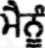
ਮੈਨੂੰ
